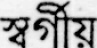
স্বর্গীয়
